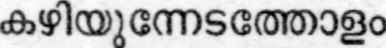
കഴിയുന്നേടത്തോളം
